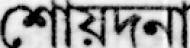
শোয়দনা
